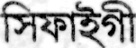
সিফাইগী
